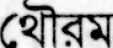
থৌরম
